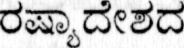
ರಷ್ಯಾದೇಶದ
